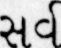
સર્વ
